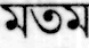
মতম
